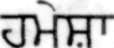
ਹਮੇਸ਼ਾ
